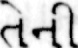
તેની
